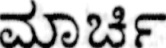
ಮಾರ್ಚಿ
